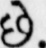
છે.
